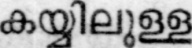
കയ്യിലുള്ള
